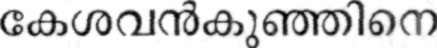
കേശവന്‍കുഞ്ഞിനെ
